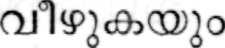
വീഴുകയും
